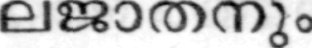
ലജാതനും
